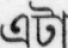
এটা
